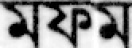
মফম
